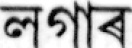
লগাৰ
